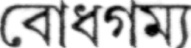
বোধগম্য
